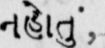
નહોતું,
